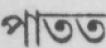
পাতত
